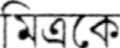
মিত্রকে
